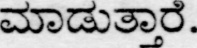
ಮಾಡುತ್ತಾರೆ.
